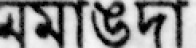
মমাঙদা
